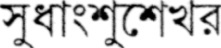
সুধাংশুশেখর
